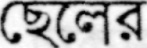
ছেলের
